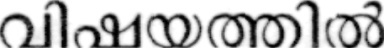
വിഷയത്തില്‍
